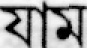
যাম
